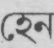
হেন
